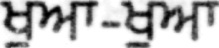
ਖੁਆ-ਖੁਆ
